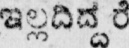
ಇಲ್ಲದಿದ್ದರೆ
